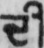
ਦੀ
